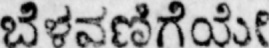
ಬೆಳವಣಿಗೆಯೇ
